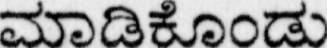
ಮಾಡಿಕೊಂಡು
